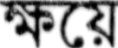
ক্ষয়ে
